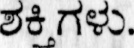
ಶಕ್ತಿಗಳು.
